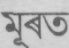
মূৰত
